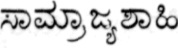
ಸಾಮ್ರಾಜ್ಯಶಾಹಿ
